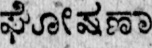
ಘೋಷಣಾ
